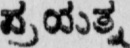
ಪ್ರಯತ್ನ
